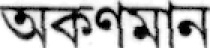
অকণমান
